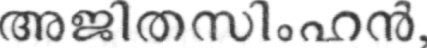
അജിതസിംഹന്‍,
